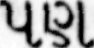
પણ
